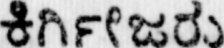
ಕಿರ್ಗೀಜರು
